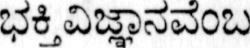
ಭಕ್ತಿವಿಜ್ಞಾನವೆಂಬ
